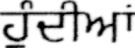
ਹੁੰਦੀਆਂ
